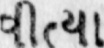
વીત્યા
